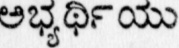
ಅಭ್ಯರ್ಥಿಯು
